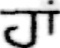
ਹਾਂ
